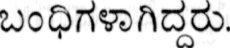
ಬಂಧಿಗಳಾಗಿದ್ದರು.
